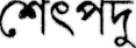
শেৎপদু
